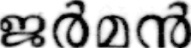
ജര്‍മന്‍
